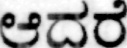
ಆದರೆ
